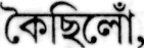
কৈছিলোঁ,
